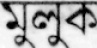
মুলুক
